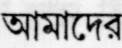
আমাদের
